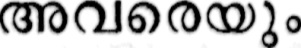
അവരെയും
